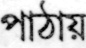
পাঠায়
